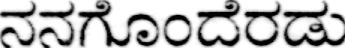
ನನಗೊಂದೆರಡು
